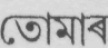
তোমাৰ
